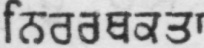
ਨਿਰਰਥਕਤਾ
